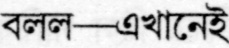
বলল–এখানেই
